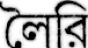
লৈরি
